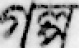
গল্প
